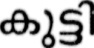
കുട്ടി
